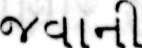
જવાની
